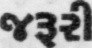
જરૂરી
